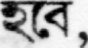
হবে,
